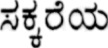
ಸಕ್ಕರೆಯ
